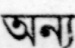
অন্য
